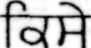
ਕਿਸੇ
